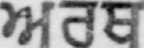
ਅਰਥ
